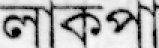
লাকপা
